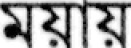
ময়ায়
